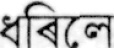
ধৰিলে
